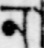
না
